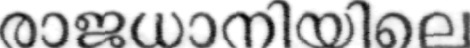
രാജധാനിയിലെ
